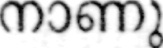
നാണു
